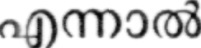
എന്നാല്‍
